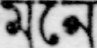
মনে
